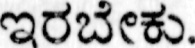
ಇರಬೇಕು.
